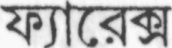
ফ্যারেক্স
